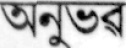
অনুভৱ
